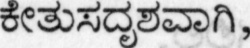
ಕೇತುಸದೃಶವಾಗಿ,
